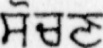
ਸੋਚਣ
